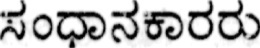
ಸಂಧಾನಕಾರರು
